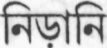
নিড়ানি
